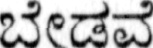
ಬೇಡವೆ
